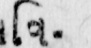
અવિ-
